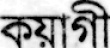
কয়াগী
